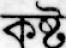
কষ্ট
